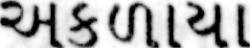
અકળાયા
